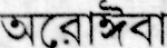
অরোঈবা
